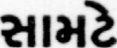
સામટે
